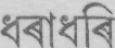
ধৰাধৰি
